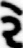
રે
